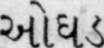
ઓઘડ
